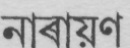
নাৰায়ণ
